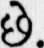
છે.
